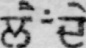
ਲੈਂਦੇ
